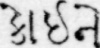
કોઈને
